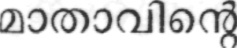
മാതാവിന്റെ
